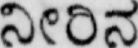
ನೀರಿನ
